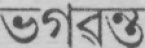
ভগৱন্ত
